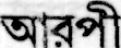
আরপী
